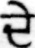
ਦੇ
